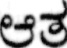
ಆತ
